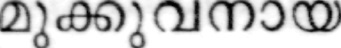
മുക്കുവനായ
